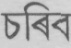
চৰিব
